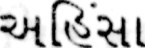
અહિંસા
